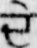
ਦੇ
